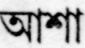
আশা
